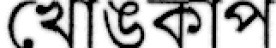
খোঙকাপ
